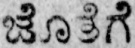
ಜೊತೆಗೆ
